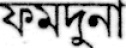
ফমদুনা
